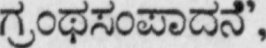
ಗ್ರಂಥಸಂಪಾದನೆ,
